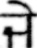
ਜੇ
